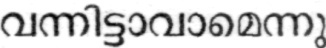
വന്നിട്ടാവാമെന്നു
